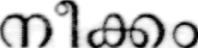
നീക്കം
